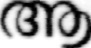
ആ
